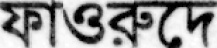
ফাওরুদে
